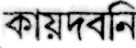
কায়দবনি
